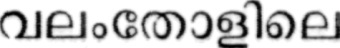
വലംതോളിലെ
